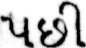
પછી
